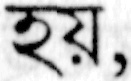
হয়,
